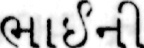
ભાઈની
